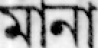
মানা
